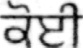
ਕੋਈ
